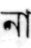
না
